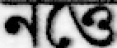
নত্তে
